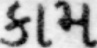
કામ
